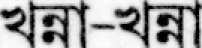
খন্না-খন্না
